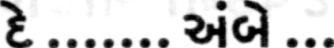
દે........અંબે....
